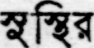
সুস্থির
